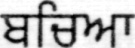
ਬਚਿਆ
